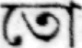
তো
